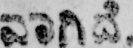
ವಾಗಿದೆ.
